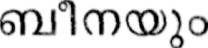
ബീനയും
